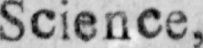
Science,
